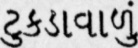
ટુકડાવાળું
